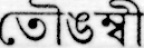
তৌঙম্বী
